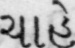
ચાહે
